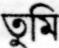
তুমি
